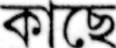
কাছে
